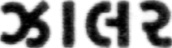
ઝાલર
